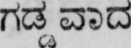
ಗಡ್ಡವಾದ
